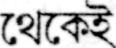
থেকেই
